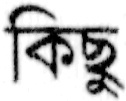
কিছু
